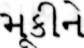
મુકીને
